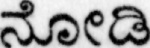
ನೋಡಿ
